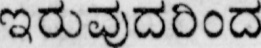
ಇರುವುದರಿಂದ
